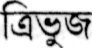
ত্রিভুজ
